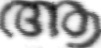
ആ
